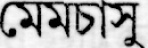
মেমচাসু
